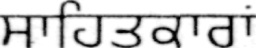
ਸਾਹਿਤਕਾਰਾਂ
